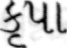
કૃપા
